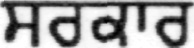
ਸਰਕਾਰ
